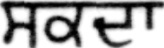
ਸਕਦਾ
